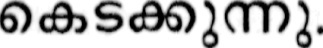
കെടക്കുന്നു.
